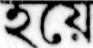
হয়ে
